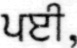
ਪਈ,
